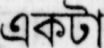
একটা
